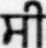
ਸੀ
